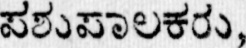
ಪಶುಪಾಲಕರು,
